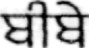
ਬੀਬੇ
